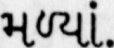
મળ્યાં.
